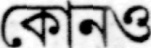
কোনও
